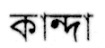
কান্দা
